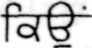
ਕਿਉਂ
